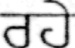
ਰਹੇ
